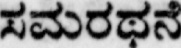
ಸಮರಥನೆ
